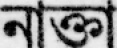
নাক্তা
